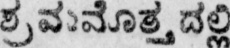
ಶ್ರಮಮೊತ್ತದಲ್ಲಿ
